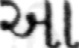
આ
